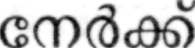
നേര്‍ക്ക്
